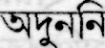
অদুননি
